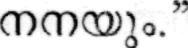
നനയും."
